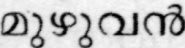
മുഴുവന്‍
